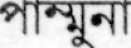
পাম্মুনা
